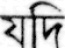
যদি
